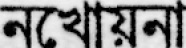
নখোয়না
